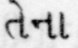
તેના
